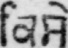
ਕਿਸੇ
